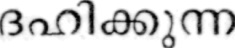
ദഹിക്കുന്ന
